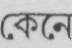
কেনে
